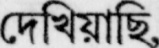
দেখিয়াছি,
